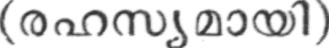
(രഹസ്യമായി)
